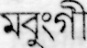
মবুংগী
